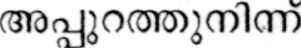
അപ്പുറത്തുനിന്ന്
